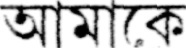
আমাকে
